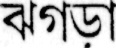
ঝগড়া
